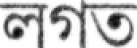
লগত
